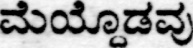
ಮೆಯ್ದೊಡವು
